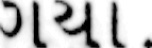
ગયા.
